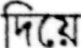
দিয়ে
